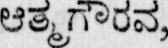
ಆತ್ಮಗೌರವ,
